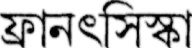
ফ্রানৎসিস্কা
